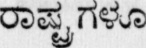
ರಾಷ್ಟ್ರಗಳೂ
